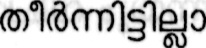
തീര്‍ന്നിട്ടില്ലാ
